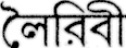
লৈরিবী
